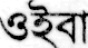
ওইবা
